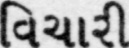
વિચારી
